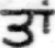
ਤਾਂ
